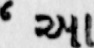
'આ
